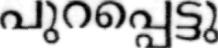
പുറപ്പെട്ടു
